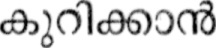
കുറിക്കാന്‍
